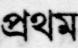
প্রথম
